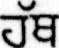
ਹੱਥ
